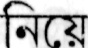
নিয়ে
